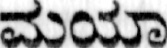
ಮಯಾ
